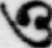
ও
